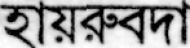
হায়রুবদা
